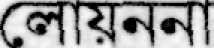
লোয়ননা
